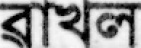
ৱাখল
